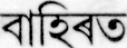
বাহিৰত
